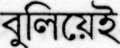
বুলিয়েই
